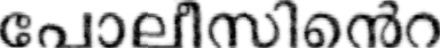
പോലീസിന്റെ
